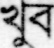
খুব
